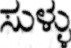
ಸುಳ್ಳು
